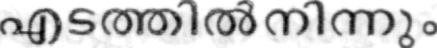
എടത്തില്‍നിന്നും
